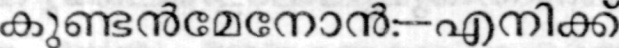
കുണ്ടന്‍മേനോന്‍:-എനിക്ക്
